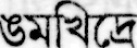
ঙমখিদ্রে
